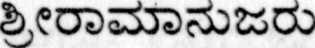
ಶ್ರೀರಾಮಾನುಜರು
